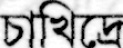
চাখিদ্রে
